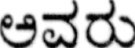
ಅವರು
